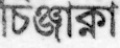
চিঞ্জাক্না
